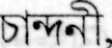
চান্দনী,
